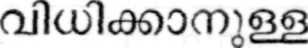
വിധിക്കാനുള്ള
